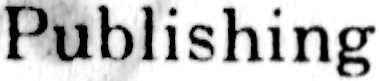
Publishing
